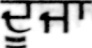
ਦੂਜਾ
